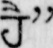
ਹੈ''
